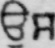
ਉਸ
